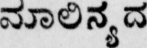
ಮಾಲಿನ್ಯದ
